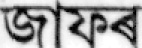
জাফৰ
